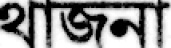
থাজনা
